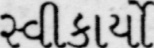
સ્વીકાર્યો
